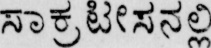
ಸಾಕ್ರಟೀಸನಲ್ಲಿ
